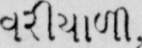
વરીયાળી,
